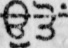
ਉਤੋਂ
